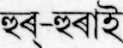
হুৰ্‌-হুৰাই
